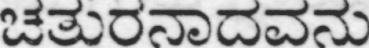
ಚತುರನಾದವನು
